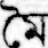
মৈ
